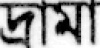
দ্রামা
